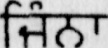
ਜਿੰਨਾ
